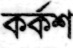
কর্কশ
